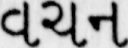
વચન
